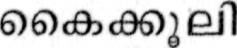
കൈക്കൂലി
